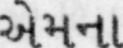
એમના
